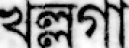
খল্লগা
